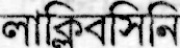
লাক্লিবসিনি
